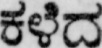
ಕಳೆದ
